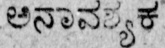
ಅನಾವಶ್ಯಕ
